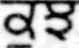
ਕੁਝ
